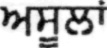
ਅਸੂਲਾਂ
